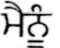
ਮੈਨੂੰ
